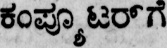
ಕಂಪ್ಯೂಟರ್‌ಗೆ
